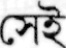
সেই
